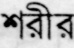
শরীর
